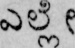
ಎಲ್ಲೇ
